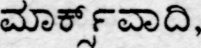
ಮಾರ್ಕ್ಸ್‌ವಾದಿ,
